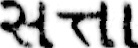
સત્તા
